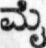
ಮೈ
